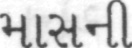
માસની
